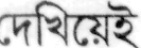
দেখিয়েই
